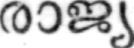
രാജ്യ
